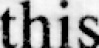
this
